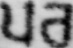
ਪਰ
